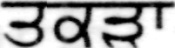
ਤਕੜਾ
